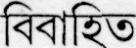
বিবাহিত
